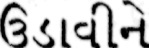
ઉડાવીને
